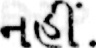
નહીં.
